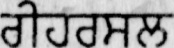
ਰੀਹਰਸਲ
